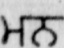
ਮਨ
